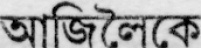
আজিলৈকে
